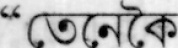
"তেনেকৈ
